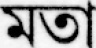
মতা
